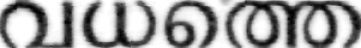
വധത്തെ
